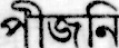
পীজনি
